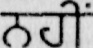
ਨਹੀਂ
